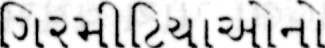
ગિરમીટિયાઓનો
